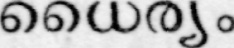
ധൈര്യം
